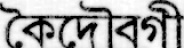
কৈদৌবগী
